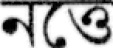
নত্তে
